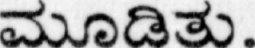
ಮೂಡಿತು.
